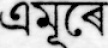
এমূৰে
